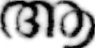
ആ
